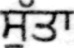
ਸੁੱਤਾ
